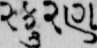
સ્ફુરણ
